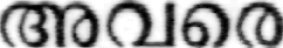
അവരെ
